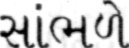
સાંભળે
